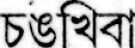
চঙখিবা
